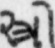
સ્ત્રી
